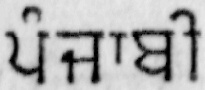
ਪੰਜਾਬੀ
